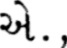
એ.,
